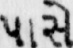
પાસે
